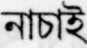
নাচাই
